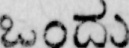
ಒಂದು
